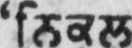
'ਨਿਕਲ
